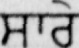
ਸਾਰੇ
